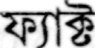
ফ্যাক্ট
